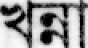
খন্না
